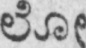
ಲೋ
